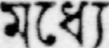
মধ্যে
